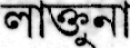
লাক্তুনা
